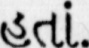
હતાં.
